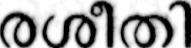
രശീതി
